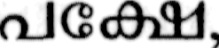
പക്ഷേ,
